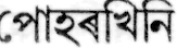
পোহৰখিনি
